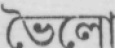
ভৈলো
